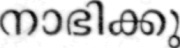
നാഭിക്കു
